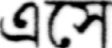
এসে
